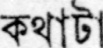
কথাটা
